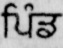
ਪਿੰਡ
